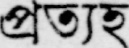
প্রত্যহ
